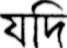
যদি
